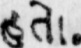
હતો.
